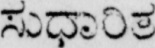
ಸುಧಾರಿತ
